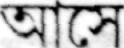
আসে
